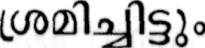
ശ്രമിച്ചിട്ടും
